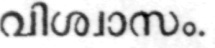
വിശ്വാസം.
